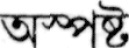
অস্পষ্ট
